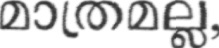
മാത്രമല്ല,
